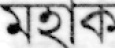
মহাক
